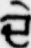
ਦੇ
